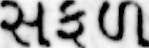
સફળ
